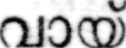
വായ്
